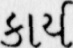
કાર્ય
